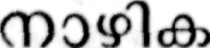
നാഴിക
